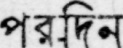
পরদিন
